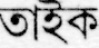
তাইক
